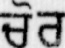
ਚੋਰ
